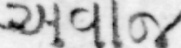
અવાજ
